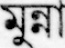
মুন্না
